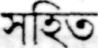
সহিত
